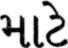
માટે
